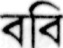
ববি
